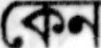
কেন
